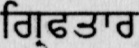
ਗ੍ਰਿਫਤਾਰ
